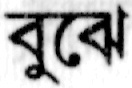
বুঝে
